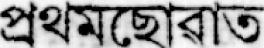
প্রথমছোৱাত
